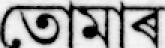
তোমাৰ
